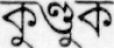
কুণ্ডুক
